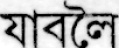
যাবলৈ
